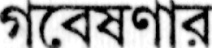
গবেষণার
